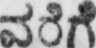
ವರೆಗೆ
